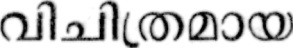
വിചിത്രമായ
